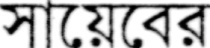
সায়েবের
